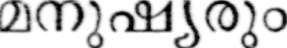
മനുഷ്യരും
